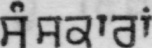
ਸੰਸਕਾਰਾਂ
